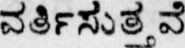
ವರ್ತಿಸುತ್ತವೆ
